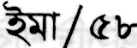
ইমা/৫৮
